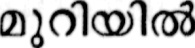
മുറിയില്‍
